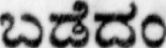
ಬಡೆದಂ
